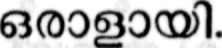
ഒരാളായി.
